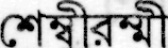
শেম্বীরম্মী
